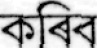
কৰিব
